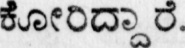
ಕೋರಿದ್ದಾರೆ.
